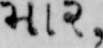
માર,
